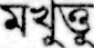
মখুত্তু
